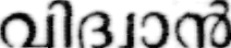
വിദ്വാന്‍
